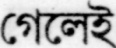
গেলেই
